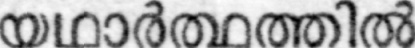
യഥാര്‍ത്ഥത്തില്‍
